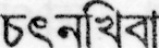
চৎনখিবা
